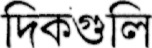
দিকগুলি
